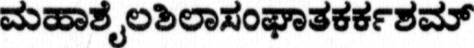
ಮಹಾಶೈಲಶಿಲಾಸಂಘಾತಕರ್ಕಶಮ್
